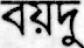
বয়দু
